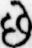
છે
